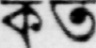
কত
